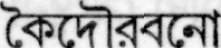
কৈদৌরবনো
